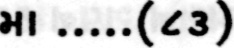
મા.....(૮૩)
